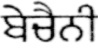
ਬੇਚੈਨੀ
